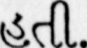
હતી.
